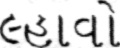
લ્હાવો
